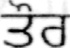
ਤੌਰ
